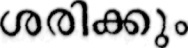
ശരിക്കും
